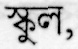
স্কুল,
